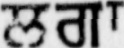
ਲਗਾ
